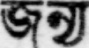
জন্য
